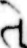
તે
